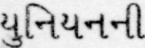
યુનિયનની
